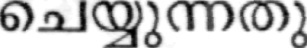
ചെയ്യുന്നതു
